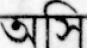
অসি
